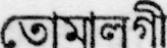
তোমালগী
